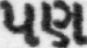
પણ
